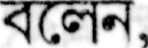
বলেন,
